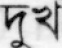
দুখ
